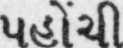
પહોંચી
